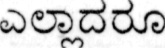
ಎಲ್ಲಾದರೂ
